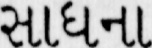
સાધના
